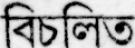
বিচলিত
